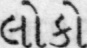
લોકો
